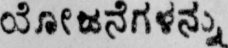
ಯೋಜನೆಗಳನ್ನು
